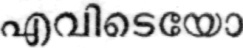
എവിടെയോ
